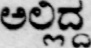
ಅಲ್ಲಿದ್ದ
